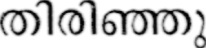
തിരിഞ്ഞു
